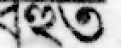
বহুত
